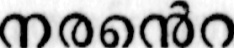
നരന്റെ
